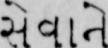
સેવાને
